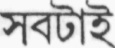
সবটাই
